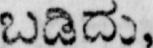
ಬಡಿದು,
